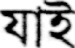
যাই
